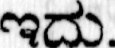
ಇದು.
